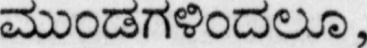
ಮುಂಡಗಳಿಂದಲೂ,
